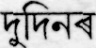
দুদিনৰ
